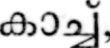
കാച്ച്,
